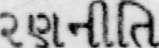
રણનીતિ
